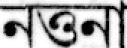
নত্তনা
